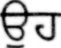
ਉਹ
